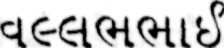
વલ્લભભાઈ
